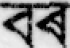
বৰ
